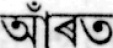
আঁৰত
